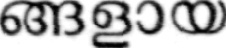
ങ്ങളായ
